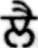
ਲੈ
